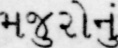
મજુરોનું
